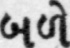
બળે
